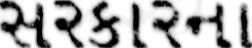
સરકારના
